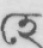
হে
